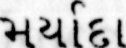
મર્યાદા
